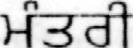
ਮੰਤਰੀ
